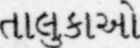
તાલુકાઓ
